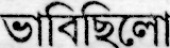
ভাবিছিলো
